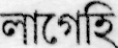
লাগেহি
